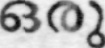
ഒരു
